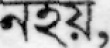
নহয়,
